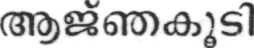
ആജ്ഞകൂടി
